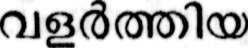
വളര്‍ത്തിയ
